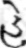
હે
